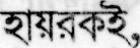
হায়রকই,
